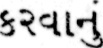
કરવાનું
